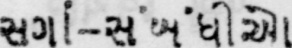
સગાં-સંબંધીઓ
